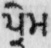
ਪ੍ਰੇਮ
